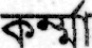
কর্ম্মা
